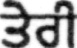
ਤੇਰੀ
